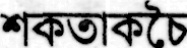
শকতাকচৈ
